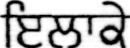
ਇਲਾਕੇ
